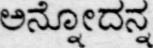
ಅನ್ನೋದನ್ನ
